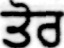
ਤੋਰ
